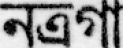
নত্রগা
